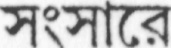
সংসারে
